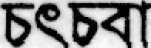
চৎচবা
